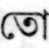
তো
